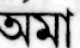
অমা
